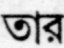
তার
